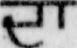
ਦਾ
